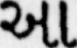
આ
